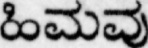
ಹಿಮವು
